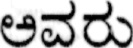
ಅವರು
